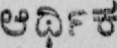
ಆರ್ಥಿಕ
